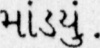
માંડયું.
